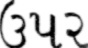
ઉપર
